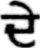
ਦੇ
